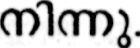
നിന്നു.
